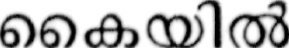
കൈയില്‍
